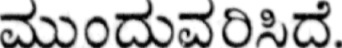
ಮುಂದುವರಿಸಿದೆ.
